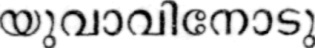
യുവാവിനോടു
